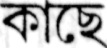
কাছে
